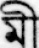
মী
